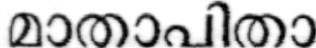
മാതാപിതാ
